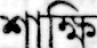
শাক্ষি
